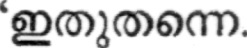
‘ഇതുതന്നെ.
